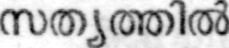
സത്യത്തില്‍
